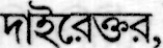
দাইরেক্তর,
